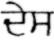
ਦੇਸ
